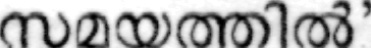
സമയത്തില്‍'
